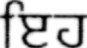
ਇਹ
